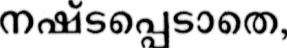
നഷ്ടപ്പെടാതെ,
